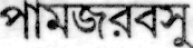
পামজরবসু
